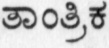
ತಾಂತ್ರಿಕ
